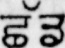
ਛੱਡ
